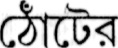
ঠোঁটের
